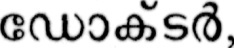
ഡോക്ടര്‍,
